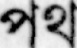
পথ
